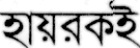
হায়রকই
